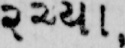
રચ્યા,
